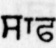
ਸਾਫ
